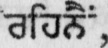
ਰਹਿਨੈਂ,
